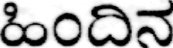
ಹಿಂದಿನ
